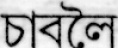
চাবলৈ
